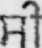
ਸੀ
